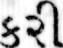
કરી
